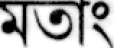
মতাং
